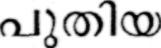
പുതിയ
